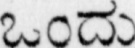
ಒಂದು
